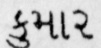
કુમાર
